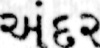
અંદર
